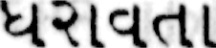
ધરાવતા
